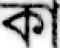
কা
